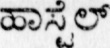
ಹಾಸ್ಟೆಲ್
